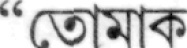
"তোমাক
